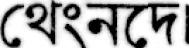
থেংনদে।
